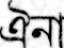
ঐনা
